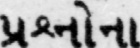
પ્રશ્નોના
